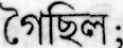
গৈছিল;
